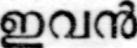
ഇവന്‍
